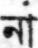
না
